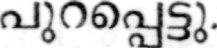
പുറപ്പെട്ടു.
